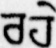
ਰਹੇ
